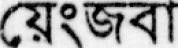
য়েংজবা
